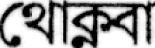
থোক্নবা
